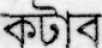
কটাব
